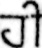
ਹੀ
